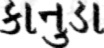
કાનુડા
